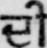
ਦੀ
